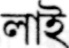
লাই
